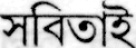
সবিতাই
